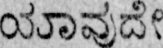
ಯಾವುದೇ
